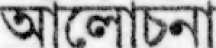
আলোচনা
